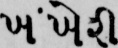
ખંખેરી
